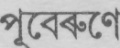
পূবেৰুণে
